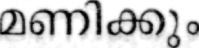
മണിക്കും
